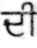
ਦੀ
